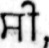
ਸੀ,
